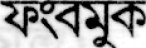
ফংবমুক
